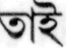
তাই
